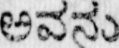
ಅವನು
